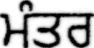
ਮੰਤਰ
